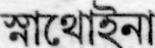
স্নাথোইনা
